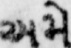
અમે
